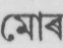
মোৰ
